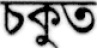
চকুত
